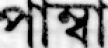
পাম্বা
